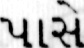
પાસે
